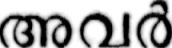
അവര്‍
